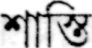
শাস্তি
